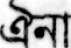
ঐনা
